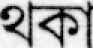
থকা
